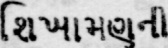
શિખામણની
